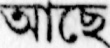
আছে
